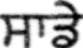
ਸਾਡੇ
